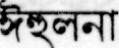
ঈহুলনা
